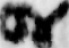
જ
